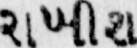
રાખીશ
